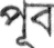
পূব
